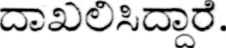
ದಾಖಲಿಸಿದ್ದಾರೆ.
